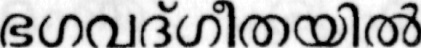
ഭഗവദ്ഗീതയില്‍
